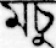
মচু
